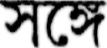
সঙ্গে
